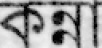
কন্না
